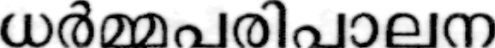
ധര്‍മ്മപരിപാലന
